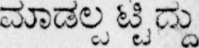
ಮಾಡಲ್ಪಟ್ಟಿದ್ದು
